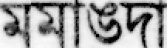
মমাঙদা
